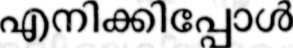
എനിക്കിപ്പോള്‍
